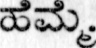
ಹೆಮ್ಮೆ.
